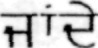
ਜਾਂਦੇ
